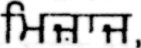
ਮਿਜ਼ਾਜ,
